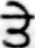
ਤੇ
